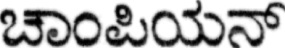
ಚಾಂಪಿಯನ್
